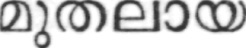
മുതലായ
